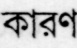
কারণ
